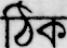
ঠিক
